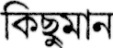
কিছুমান
